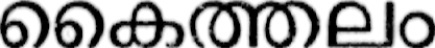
കൈത്തലം
